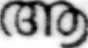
ആ
